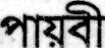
পায়বী
